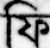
ফি
